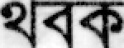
থবক
